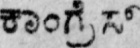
ಕಾಂಗ್ರೆಸ್
